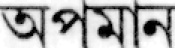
অপমান
